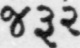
જરૂર
